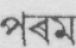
পৰম
